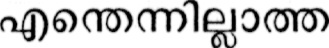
എന്തെന്നില്ലാത്ത
